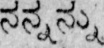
ನನ್ನನ್ನು
